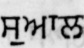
ਸੁਆਲ
